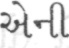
એની
